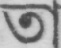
তা
